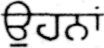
ਉਹਨਾਂ
